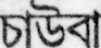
চাউবা
